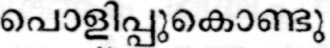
പൊളിപ്പുകൊണ്ടു
